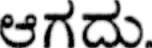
ಆಗದು.
